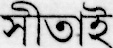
সীতাই
